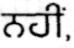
ਨਹੀਂ,
